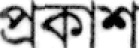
প্রকাশ
